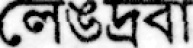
লেঙদ্রবা
